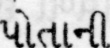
પોતાની
